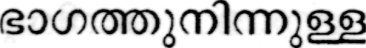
ഭാഗത്തുനിന്നുള്ള
